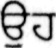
ਉਹ
